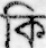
কি
